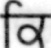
ਕਿ
